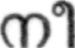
നീ
